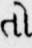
તો
